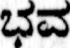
ಭವ
